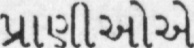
પ્રાણીઓએ
